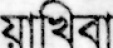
য়াখিবা
